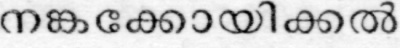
നങ്കക്കോയിക്കല്‍
